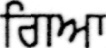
ਗਿਆ
